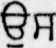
ਉਸ
